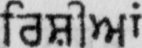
ਰਿਸ਼ੀਆਂ
